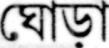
ঘোড়া
